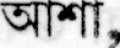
আশা,
